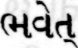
ભવેત્
